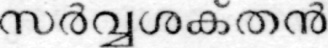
സര്‍വ്വശക്തന്‍
